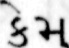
કેમ
